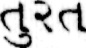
તુરત
